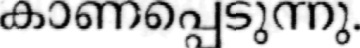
കാണപ്പെടുന്നു.
